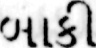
બાકી
